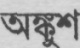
অঙ্কুশ
